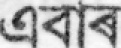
এবাৰ
